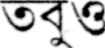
তবুও
